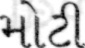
મોટી
